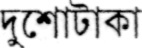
দুশোটাকা
